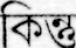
কিন্তু
